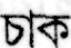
চাক
